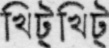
খিট্‌খিট্
